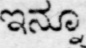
ಇನ್ನೂ
